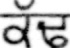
ਕੱਢ
